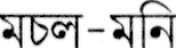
মচল-মনি
